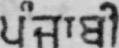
ਪੰਜਾਬੀ
